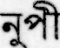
নুপী
